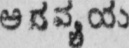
ಅಪವ್ಯಯ
